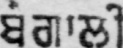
ਬੰਗਾਲੀ
